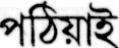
পঠিয়াই
